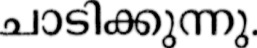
ചാടിക്കുന്നു.
